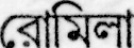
রোমিলা
